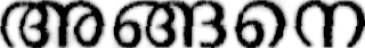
അങ്ങനെ
